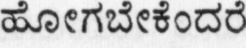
ಹೋಗಬೇಕೆಂದರೆ
